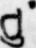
તું
